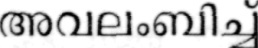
അവലംബിച്ച്
